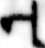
ન
